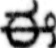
ಈ
